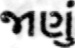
જાણું
